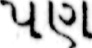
પણ
